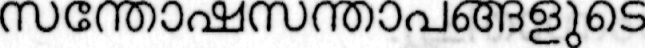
സന്തോഷസന്താപങ്ങളുടെ
